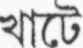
খাটে
